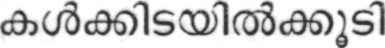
കള്‍ക്കിടയില്‍ക്കൂടി
